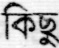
কিছু
